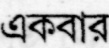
একবার
